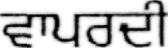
ਵਾਪਰਦੀ
